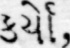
કર્યો,
